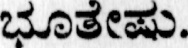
ಭೂತೇಷು.
